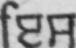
ਇਸ
